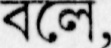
বলে,
